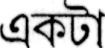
একটা
